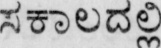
ಸಕಾಲದಲ್ಲಿ
